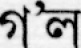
গ'ল
